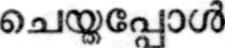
ചെയ്തപ്പോള്‍
